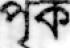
পৃক
